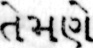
તેમણે
